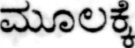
ಮೂಲಕ್ಕೆ
